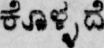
ಕೊಳ್ಳದೆ
